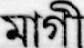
মাগী
